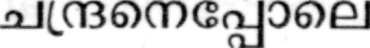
ചന്ദ്രനെപ്പോലെ
